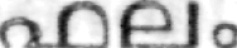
ഫലം
